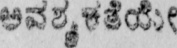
ಅವಶ್ಯಕತೆಯೇ
